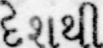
દેશથી
